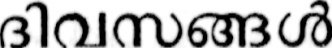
ദിവസങ്ങള്‍
